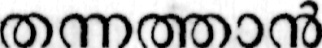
തന്നത്താന്‍
